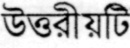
উত্তরীয়টি
